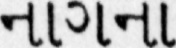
નાગના
